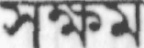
সক্ষম
